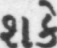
શકે
